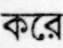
করে
